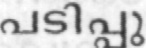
പടിപ്പു
